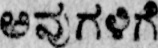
ಅವುಗಳಿಗೆ
